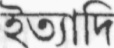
ইত্যাদি
